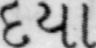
દયા
